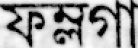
ফম্লগা
